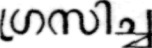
ഗ്രസിച്ച
